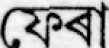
ফেৰা
